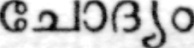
ചോദ്യം
